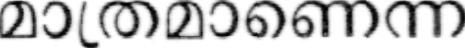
മാത്രമാണെന്ന
